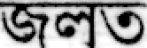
জলত
